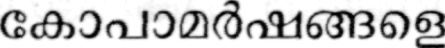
കോപാമര്‍ഷങ്ങളെ
